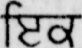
ਇਕ
